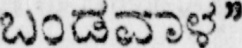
ಬಂಡವಾಳ”
